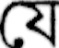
যে
